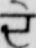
ਦੇ
